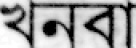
খনবা
